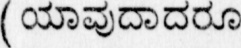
(ಯಾವುದಾದರೂ
